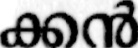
ക്കന്‍
